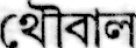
থৌবাল
